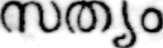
സത്യം
